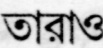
তারাও
